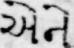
એને
